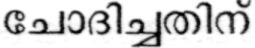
ചോദിച്ചതിന്
